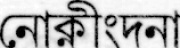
নোক্নীংদনা
